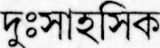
দুঃসাহসিক
